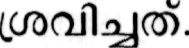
ശ്രവിച്ചത്.
